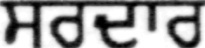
ਸਰਦਾਰ
